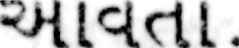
આવતા.
